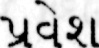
પ્રવેશ
